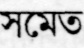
সমেত
